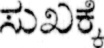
ಸುಖಕ್ಕೆ
